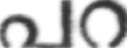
പറ
